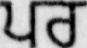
ਪਰ
